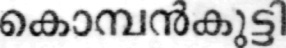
കൊമ്പന്‍കുട്ടി
